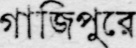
গাজিপুরে
